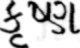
કૃષ્ણ
